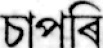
চাপৰি
